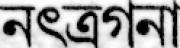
নৎত্রগনা
